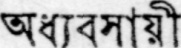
অধ্যবসায়ী
